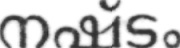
നഷ്ടം
